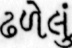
ઢળેલું
